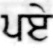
ਪਏ
